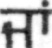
ਜਾਂ
